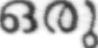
ഒരു
